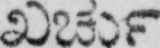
ಖರ್ಚು
